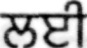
ਲਈ
